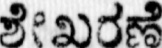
ಶೇಖರಣೆ
